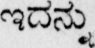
ಇದನ್ನು
